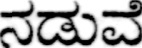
ನಡುವೆ
